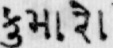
કુમારો
